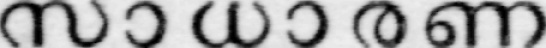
സാധാരണ
